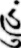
હું
